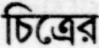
চিত্রের
